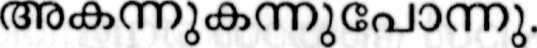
അകന്നുകന്നുപോന്നു.
